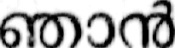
ഞാന്‍
